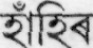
হাঁহিৰ
